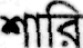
শারি
